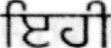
ਇਹੀ
